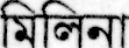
মিলিনা
